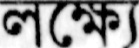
লক্ষ্যে
